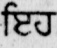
ਇਹ
